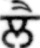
ਲੈ
